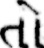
તો
